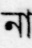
না
